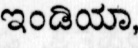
ಇಂಡಿಯಾ,
